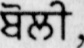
ਬੋਲੀ,
